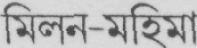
মিলন-মহিমা
